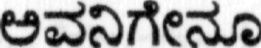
ಅವನಿಗೇನೂ
